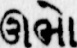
ઊભો
